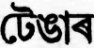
টেঙাৰ
